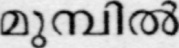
മുമ്പില്‍
